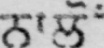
ਨਾਲੋਂ
